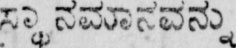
ಸ್ಥಾನಮಾನವನ್ನು
